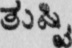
ತುಷ್ಟಿ
